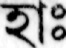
হাঃ
